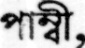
পাম্বী,
